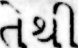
તેથી
